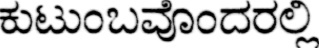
ಕುಟುಂಬವೊಂದರಲ್ಲಿ
